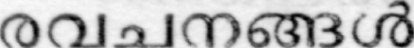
രവചനങ്ങള്‍
